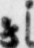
કાં
